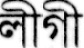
লীগী
